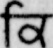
ਕਿ
